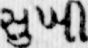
સુખી
